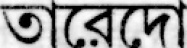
তারেদো
